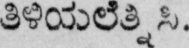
ತಿಳಿಯಲೆತ್ನಿಸಿ.
